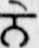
ਨੇ
